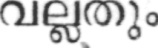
വല്ലതും
